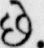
છે.
